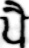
ਪੈ
